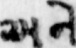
અને
